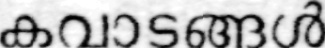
കവാടങ്ങള്‍
